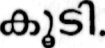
കൂടി.
